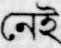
নেই
